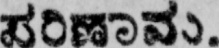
ಪರಿಣಾಮ.
